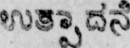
ಉತ್ಪಾದನೆ
